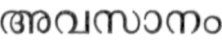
അവസാനം
